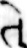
તે
